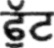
ਫੁੱਟ
